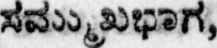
ಸಮ್ಮುಖಭಾಗ,
